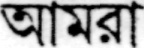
আমরা
